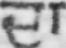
ਦਾ
